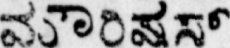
ಮೌರಿಷಸ್
